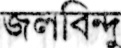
জলবিন্দু
